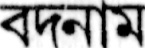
বদনাম
